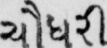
ચૌધરી
